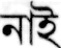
নাই
